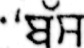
''ਬੱਸ
